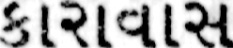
કારાવાસ
